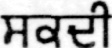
ਸਕਦੀ
